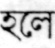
হলে
